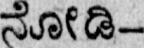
ನೋಡಿ-
